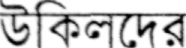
উকিলদের
